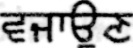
ਵਜਾਉਣ
